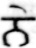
ਨੇ
